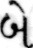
બે
